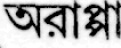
অরাপ্পা
